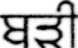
ਬੜੀ
